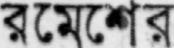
রমেশের
